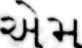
એમ
